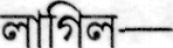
লাগিল-
